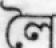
লৈ
